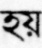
হয়
